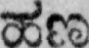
ಹಣ
